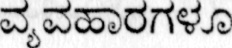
ವ್ಯವಹಾರಗಳೂ
